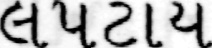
લપટાય
